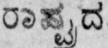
ರಾಷ್ಟ್ರದ
